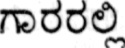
ಗಾರರಲ್ಲಿ
